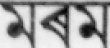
মৰম
